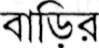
বাড়ির
